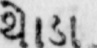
થોડા.
